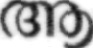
ആ
